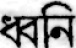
ধ্বনি
